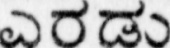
ಎರಡು
